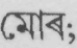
মোৰ;
